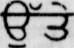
ਉੱਤੇ
